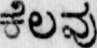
ಕೆಲವು
